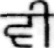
ਵੀ
